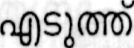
എടുത്ത്
